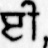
ਈ,
